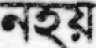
নহয়
